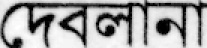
দেবলানা
